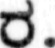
ರ.
